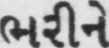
ભરીને
